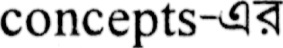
concepts-এর
